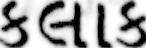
કલાક
